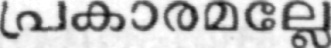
പ്രകാരമല്ലേ
